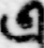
এ
